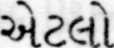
એટલો
